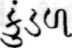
કુંડળ
